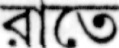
রাতে
